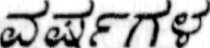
ವರ್ಷಗಳ
